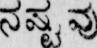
ನಷ್ಟವು
